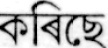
কৰিছে
